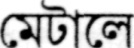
মেটালে
